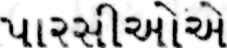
પારસીઓએ
